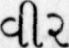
વીર
